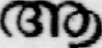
ആ
